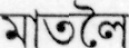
মাতলৈ
